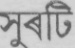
সুৰটি
